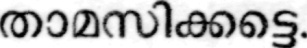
താമസിക്കട്ടെ.
